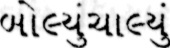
બોલ્યુંચાલ્યું
